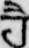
ਹੈ
